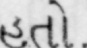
હતો.
